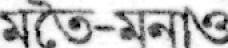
মতৈ-মনাও
